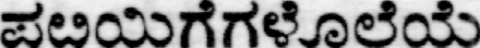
ಪೞಯಿಗೆಗಳೊಲೆಯೆ
